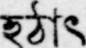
হঠাৎ
